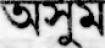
অসুম
